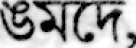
ঙমদে,
